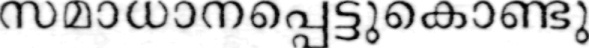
സമാധാനപ്പെട്ടുകൊണ്ടു
